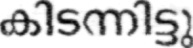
കിടന്നിട്ടു
